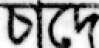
চাদে
